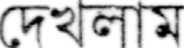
দেখলাম
